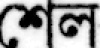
শেল
